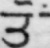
ਤੋਂ
